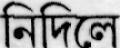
নিদিলে
